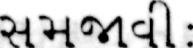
સમજાવીઃ
